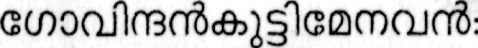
ഗോവിന്ദന്‍കുട്ടിമേനവന്‍:
